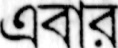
এবার
